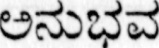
ಅನುಭವ
